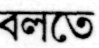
বলতে
